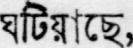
ঘটিয়াছে,
